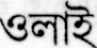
ওলাই
